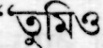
"তুমিও
